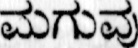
ಮಗುವು
